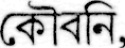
কৌবনি,
